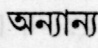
অন্যান্য
